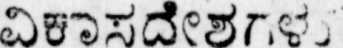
ವಿಕಾಸದೇಶಗಳು
